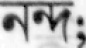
নন্দ;
